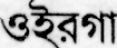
ওইরগা
